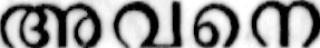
അവനെ
